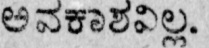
ಅವಕಾಶವಿಲ್ಲ.
